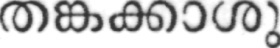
തങ്കക്കാശു
